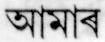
আমাৰ
